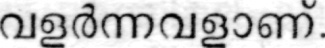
വളര്‍ന്നവളാണ്.
